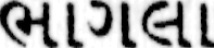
ભાગલા
